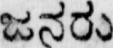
ಜನರು
